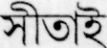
সীতাই
